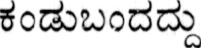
ಕಂಡುಬಂದದ್ದು
